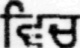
ਵਿਚ
